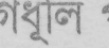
গধূলি
